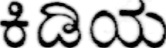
ಕಿಡಿಯ
